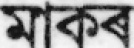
মাকৰ
